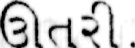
ઊતરી.
